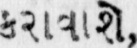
કરાવાશે,
